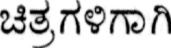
ಚಿತ್ರಗಳಿಗಾಗಿ
